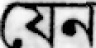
যেন
